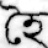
হৈ
